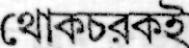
থোকচরকই
